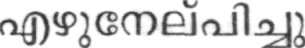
എഴുനേല്പിച്ചു
